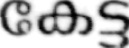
കേട്ട
